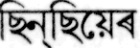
ছিন্‌ছিয়েৰ
